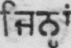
ਜਿਨ੍ਹਾਂ
